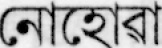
নোহোৱা
